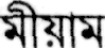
মীয়াম
